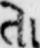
તો
